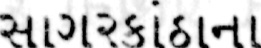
સાગરકાંઠાના
